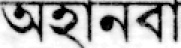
অহানবা
